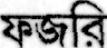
ফজরি
